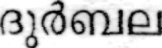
ദുര്‍ബല
